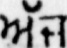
ਅੱਜ
